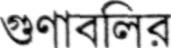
গুণাবলির
